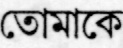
তোমাকে
